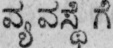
ವ್ಯವಸ್ಥೆಗೆ
